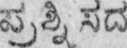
ಪ್ರಶ್ನಿಸದ
